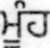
ਮੂੰਹ
